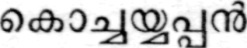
കൊച്ചയ്യപ്പന്‍
